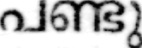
പണ്ടു
